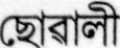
ছোৱালী
